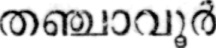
തഞ്ചാവൂര്‍
